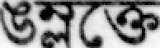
ঙম্লক্তে
